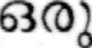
ഒരു
